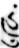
હું
